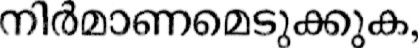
നിര്‍മാണമെടുക്കുക,
